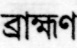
ব্রাহ্মণ
